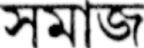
সমাজ
